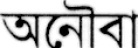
অনৌবা
